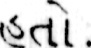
હતો.
